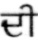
ਦੀ
